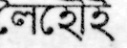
লৈহৌই
